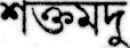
শক্তমদু
